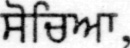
ਸੋਚਿਆ,
